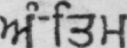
ਅੰਤਿਮ
